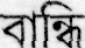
বান্ধি
